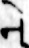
ને
